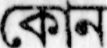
কোন
